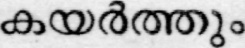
കയര്‍ത്തും
